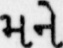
મને
